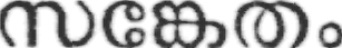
സങ്കേതം
